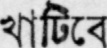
খাটিবে
